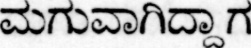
ಮಗುವಾಗಿದ್ದಾಗ
